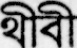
থীবী
